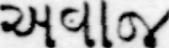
અવાજ
